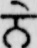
ਨੇ
